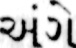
અંગે
